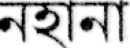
নহানা
